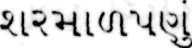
શરમાળપણું
